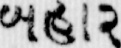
બહાર
